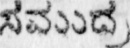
ಸಮುದ್ರ
